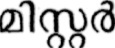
മിസ്റ്റര്‍
